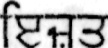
ਇਜ਼ਤ
